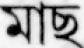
মাছ
